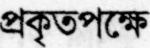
প্রকৃতপক্ষে
